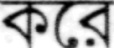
করে
